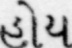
હોય
